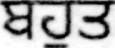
ਬਹੁਤ
